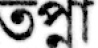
তপ্না
